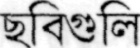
ছবিগুলি
